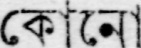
কোনো
